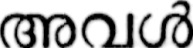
അവള്‍
